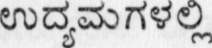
ಉದ್ಯಮಗಳಲ್ಲಿ
